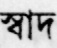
স্বাদ
